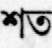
শত
